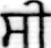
ਸੀ
